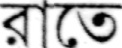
রাতে
